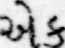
એક
